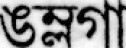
ঙম্লগা
